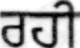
ਰਹੀ
